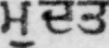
ਮੁਦਤ
